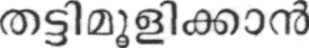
തട്ടിമൂളിക്കാന്‍
